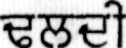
ਢਲਦੀ
